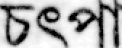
চৎপা
